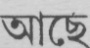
আছে
